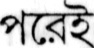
পরেই
